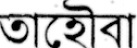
তাহৌবা
